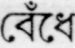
বেঁধে
